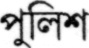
পুলিশ
